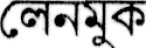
লেনমুক
